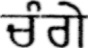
ਚੰਗੇ
